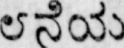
೮ನೆಯ
